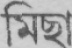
মিছা
